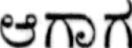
ಆಗಾಗ
